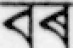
বৰ
